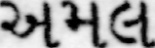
અમલ
